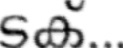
ടക്..
